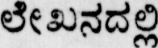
ಲೇಖನದಲ್ಲಿ
